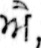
ਐ,
